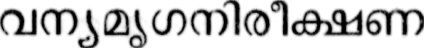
വന്യമൃഗനിരീക്ഷണ
